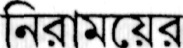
নিরাময়ের
